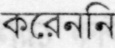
করেননি
